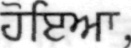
ਹੋਇਆ,
